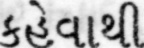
કહેવાથી
